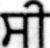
ਸੀ
